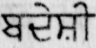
ਬਦੇਸ਼ੀ
